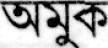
অমুক
